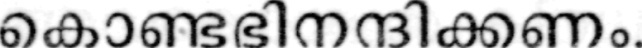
കൊണ്ടഭിനന്ദിക്കണം.
